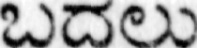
ಬದಲು
